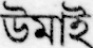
উমাই
